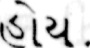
હોય.
